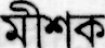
মীশক
